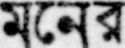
মনের
